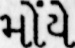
મોંયે
